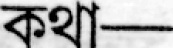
কথা-
